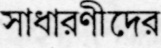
সাধারণীদের
